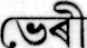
ভেৰী
